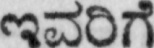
ಇವರಿಗೆ
